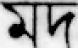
মদ
